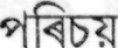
পৰিচয়
